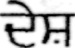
ਦੇਸ਼
